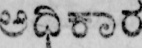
ಅಧಿಕಾರ
